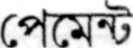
পেমেন্ট
